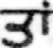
ਤਾਂ
